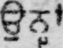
ਉਨ੍ਹਾਂ
